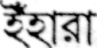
ইঁহারা
